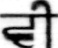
ਵੀ
